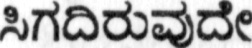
ಸಿಗದಿರುವುದೇ
